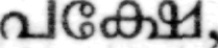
പക്ഷേ,
